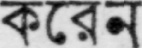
করেন
